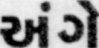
અંગે
